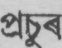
প্ৰচুৰ
